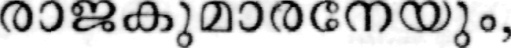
രാജകുമാരനേയും,
